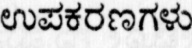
ಉಪಕರಣಗಳು
